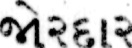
જોરદાર
